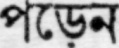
পড়েন
